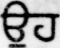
ਉਹ
